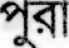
পুরা
